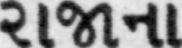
રાજાના
